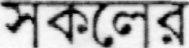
সকলের
